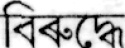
বিৰুদ্ধে
